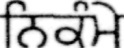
ਨਿਕੰਮੇ
